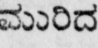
ಮುರಿದ
